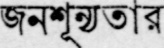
জনশূন্যতার
